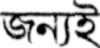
জন্যই
